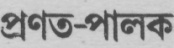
প্ৰণত-পালক
